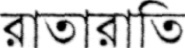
রাতারাতি
